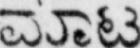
ಮಾಟ
